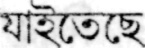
যাইতেছে
